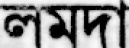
লমদা
